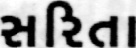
સરિતા
